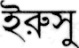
ইরুসু
